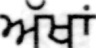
ਅੱਖਾਂ
